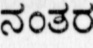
ನಂತರ
